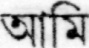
আমি
